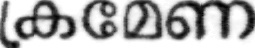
ക്രമേണ
